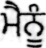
ਮੈਨੂੰ
